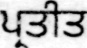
ਪ੍ਰਤੀਤ
